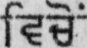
ਵਿਚੋਂ
